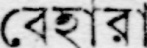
বেহারা
